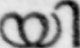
യി
